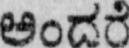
ಅಂದರೆ
